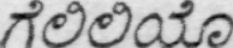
ಗೆಲಿಲಿಯೊ
